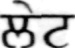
ਲੇਟ
